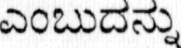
ಎಂಬುದನ್ನು
